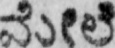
ಮೇಲೆ
